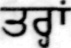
ਤਰ੍ਹਾਂ
